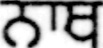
ਨਾਥ
